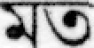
মত
